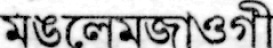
মঙলেমজাওগী
